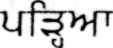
ਪੜ੍ਹਿਆ
